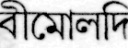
বীমোলদি
